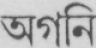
অগনি
